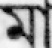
মা
